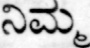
ನಿಮ್ಮ
